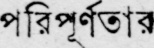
পরিপূর্ণতার
